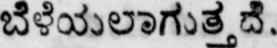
ಬೆಳೆಯಲಾಗುತ್ತದೆ.
